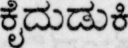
ಕೈದುಡುಕಿ
